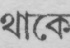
থাকে
